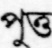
পুত্ত
